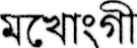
মখোংগী
